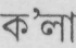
ক'লা
